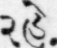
રહે.
